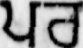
ਪਰ
